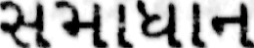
સમાધાન
